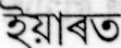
ইয়াৰত
